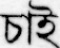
চাই
